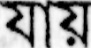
যায়
